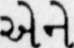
એને
